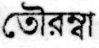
তৌরম্বা
